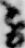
કે
